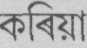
কৰিয়া
